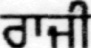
ਰਾਜੀ
